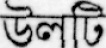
উলটি
